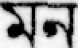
মন
